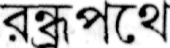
রন্ধ্রপথে
